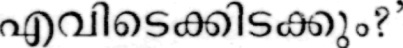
എവിടെക്കിടക്കും?'
